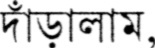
দাঁড়ালাম,
